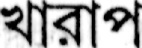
খারাপ
